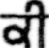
ਕੀ
